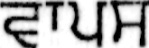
ਵਾਪਸ
